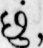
છું,
